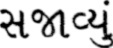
સજાવ્યું
